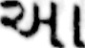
આ
